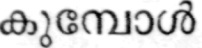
കുമ്പോള്‍
